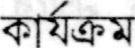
কার্যক্রম
